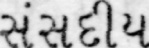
સંસદીય
